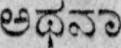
ಅಥವಾ
